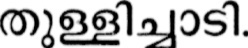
തുള്ളിച്ചാടി.
